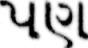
પણ
